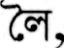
লৈ,
